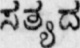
ಸತ್ಯದ
